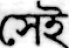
সেই
